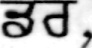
ਡਰ,
